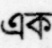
এক
